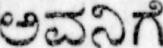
ಅವನಿಗೆ
